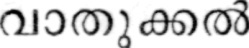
വാതുക്കല്‍
